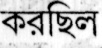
করছিল
